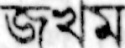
জখম
